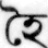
হৈ
